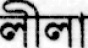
লীলা
